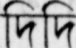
দিদি
